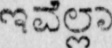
ಇವೆಲ್ಲಾ
